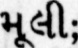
મૂલી;
